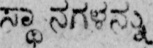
ಸ್ಥಾನಗಳನ್ನು
